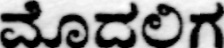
ಮೊದಲಿಗ
